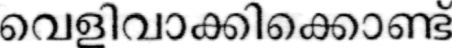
വെളിവാക്കിക്കൊണ്ട്
